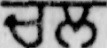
ਚਲ
